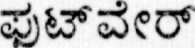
ಫುಟ್‌ವೇರ್
